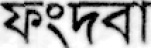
ফংদবা
